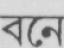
বনে
